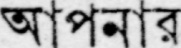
আপনার
